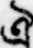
ঐ
